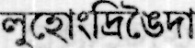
লুহোংদ্রিঙৈদা
